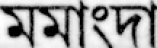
মমাংদা
